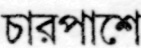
চারপাশে
